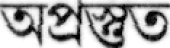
অপ্রস্তুত
